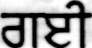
ਗਈ
